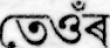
তেওঁৰ
